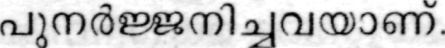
പുനര്‍ജ്ജനിച്ചവയാണ്.
